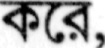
করে,
